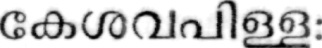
കേശവപിള്ള:
